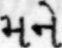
મને
